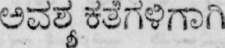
ಅವಶ್ಯಕತೆಗಳಿಗಾಗಿ
